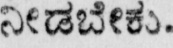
ನೀಡಬೇಕು.
